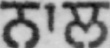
ਨਾਲ
